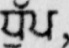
ਧੁੱਪ,
